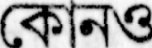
কোনও
